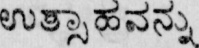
ಉತ್ಸಾಹವನ್ನು
